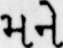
મને
